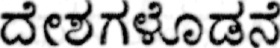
ದೇಶಗಳೊಡನೆ
